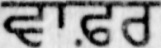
ਵਾਫ਼ਰ
